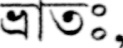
ভ্রাতঃ,
